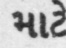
માટે
